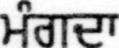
ਮੰਗਦਾ
